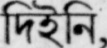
দিইনি,
